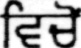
ਵਿਚੋਂ
